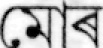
মোৰ
